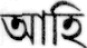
আহি
